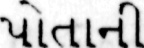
પોતાની
